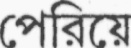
পেরিয়ে
